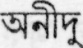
অনীদু
